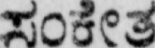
ಸಂಕೇತ
